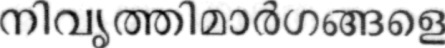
നിവൃത്തിമാര്‍ഗങ്ങളെ
